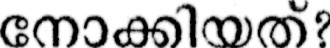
നോക്കിയത്?
